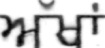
ਅੱਖਾਂ
